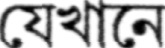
যেখানে
